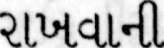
રાખવાની
